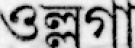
ওল্লগা
